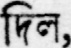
দিল,
